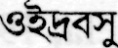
ওইদ্রবসু
